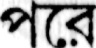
পরে
